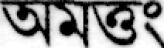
অমত্তং
